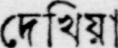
দেখিয়া
